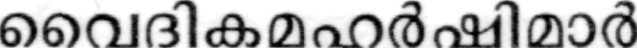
വൈദികമഹര്‍ഷിമാര്‍
